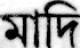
মাদি
